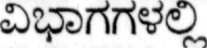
ವಿಭಾಗಗಳಲ್ಲಿ
